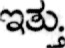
ಇತ್ತು.
